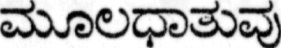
ಮೂಲಧಾತುವು
